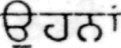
ਉਹਨਾਂ
